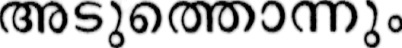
അടുത്തൊന്നും
